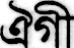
ঐগী
